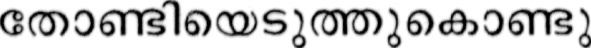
തോണ്ടിയെടുത്തുകൊണ്ടു
